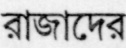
রাজাদের
